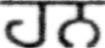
ਹਨ
